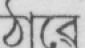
ঠাৱে
